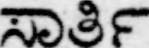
ಸಾರ್ತಿ
